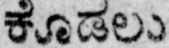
ಕೊಡಲು
